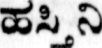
ಹಸ್ತಿನಿ
